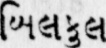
બિલકુલ
